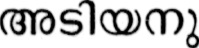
അടിയനു
